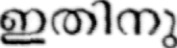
ഇതിനു
